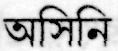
অসিনি
